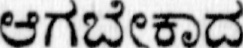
ಆಗಬೇಕಾದ
